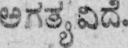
ಅಗತ್ಯವಿದೆ.
